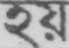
হয়
